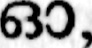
ഓ,
